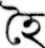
হৈ
